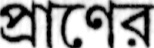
প্রাণের
